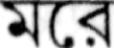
মরে
